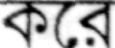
করে
